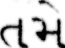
તમે
